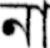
না
